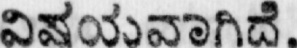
ವಿಷಯವಾಗಿದೆ.
